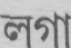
লগা
